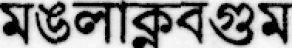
মঙলাক্লবগুম
